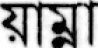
য়াম্না
